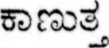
ಕಾಣುತ್ತ
